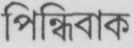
পিন্ধিবাক
